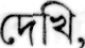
দেখি,
